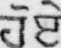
ਹੋਏ
